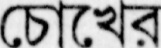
চোখের
